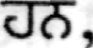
ਹਨ,
